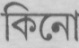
কিনো
